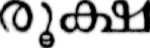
രൂക്ഷ
